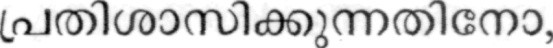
പ്രതിശാസിക്കുന്നതിനോ,
